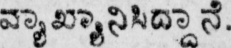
ವ್ಯಾಖ್ಯಾನಿಸಿದ್ದಾನೆ.
